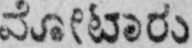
ಮೋಟಾರು
